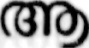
ആ
